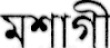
মশাগী
